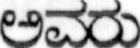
ಅವರು
